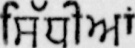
ਸਿੱਧੀਆ
